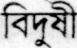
বিদুষী
